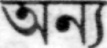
অন্য
